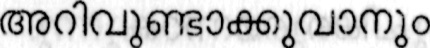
അറിവുണ്ടാക്കുവാനും
